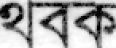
থবক
